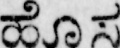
ಹೊಸ
